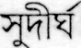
সুদীর্ঘ
